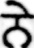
ਨੇ
